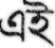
এই
